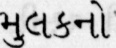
મુલકનો
